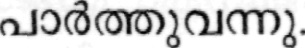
പാര്‍ത്തുവന്നു.
